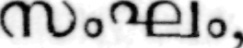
സംഘം,
